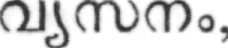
വ്യസനം,
